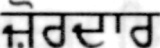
ਜ਼ੋਰਦਾਰ
